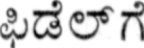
ಫಿಡೆಲ್ಗೆ
